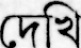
দেখি
